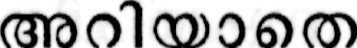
അറിയാതെ
